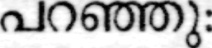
പറഞ്ഞു:
